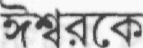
ঈশ্বরকে
